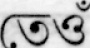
তেওঁ
